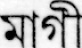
মাগী
